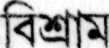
বিশ্রাম
